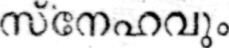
സ്നേഹവും
